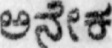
ಅನೇಕ
